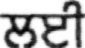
ਲਈ
